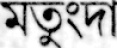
মতুংদা
